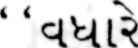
"વધારે
